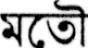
মতৌ
